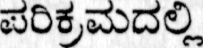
ಪರಿಕ್ರಮದಲ್ಲಿ
